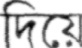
দিয়ে
